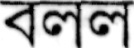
বলল
